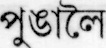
পুঙালৈ
